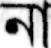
না
